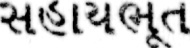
સહાયભૂત
